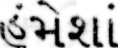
હંમેશાં
